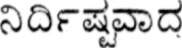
ನಿರ್ದಿಷ್ಟವಾದ
